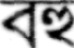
বহু
